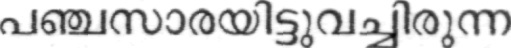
പഞ്ചസാരയിട്ടുവച്ചിരുന്ന
